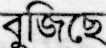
বুজিছে
